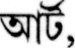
আৰ্ট,
